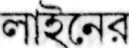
লাইনের
